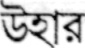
উহার
